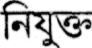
নিযুক্ত
